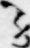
કે
